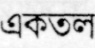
একতল
